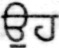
ਉਹ
